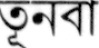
তূনবা
